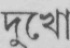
দুখো
